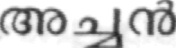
അച്ചന്‍
